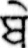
ਬੇ
